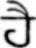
ਹੈ
